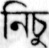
নিচু
